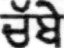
ਚੱਬੇ
